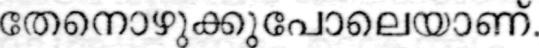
തേനൊഴുക്കുപോലെയാണ്.
